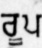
ਰੂਪ
